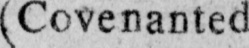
(Covenanted
